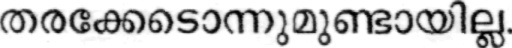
തരക്കേടൊന്നുമുണ്ടായില്ല.
